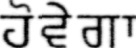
ਹੋਵੇਗਾ
